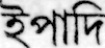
ইপাদি
